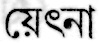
য়েৎনা
